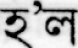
হ'ল
